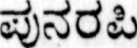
ಪುನರಪಿ
